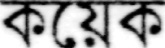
কয়েক
